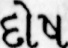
દોષ
